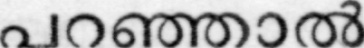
പറഞ്ഞാല്‍
